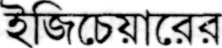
ইজিচেয়ারের
